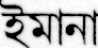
ইমানা
